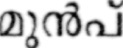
മുന്‍പ്
